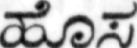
ಹೊಸ
